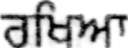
ਰਖਿਆ
